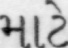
માટે
